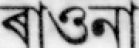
ৰাওনা
